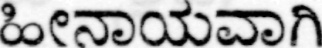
ಹೀನಾಯವಾಗಿ
